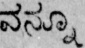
ವನ್ನೂ
